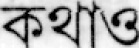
কথাও
